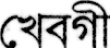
খেবগী
